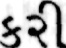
કરી
